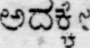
ಅದಕ್ಕೇ
